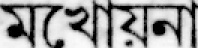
মখোয়না
